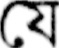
যে
